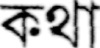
কথা
